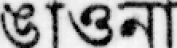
ঙাওনা
